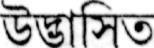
উদ্ভাসিত
